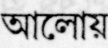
আলোয়
